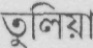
তুলিয়া
